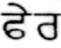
ਫੇਰ
